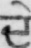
ਦੇ
